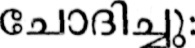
ചോദിച്ചു:
